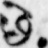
છે.
